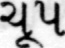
ચૂપ
